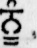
ਨੂੰ
